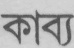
কাব্য
